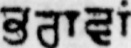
ਭਰਾਵਾਂ
